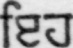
ਇਹ
